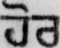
ਹੋਰ
